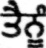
ਤੈਨੂੰ
